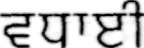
ਵਧਾਈ
